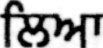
ਲਿਆ
